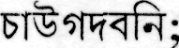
চাউগদবনি;
